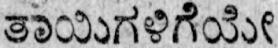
ತಾಯಿಗಳಿಗೆಯೇ
